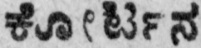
ಕೋರ್ಟಿನ
